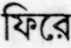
ফিরে
